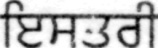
ਇਸਤਰੀ
